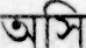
অসি
